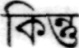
কিন্তু
